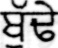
ਬੁੱਢੇ
